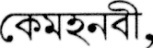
কেমহনবী,
